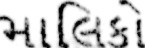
માલિકો
